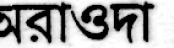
অরাওদা
